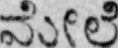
ಮೇಲೆ
